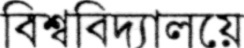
বিশ্ববিদ্যালয়ে
